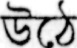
উঠে
